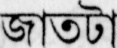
জাতটা
